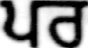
ਪਰ
